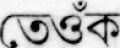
তেওঁক
